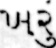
ખરું
